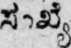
ಸಂಖ್ಯೆ
